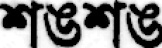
শঙশঙ
